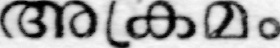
അക്രമം
